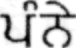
ਪੰਨੇ
